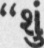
“શું
